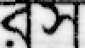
রস
